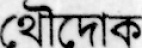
থৌদোক
